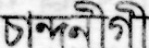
চান্দনীগী
